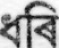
ধৰি
